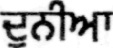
ਦੁਨੀਆ
